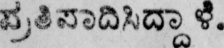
ಪ್ರತಿಪಾದಿಸಿದ್ದಾಳೆ.
